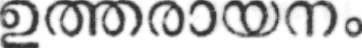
ഉത്തരായനം
